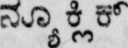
ನ್ಯೂಕ್ಲಿಕ್
